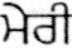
ਮੇਰੀ
